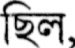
ছিল,
